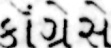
કોંગ્રેસે
